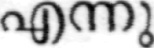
എന്നു
